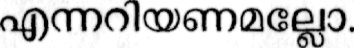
എന്നറിയണമല്ലോ.
